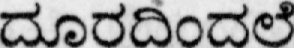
ದೂರದಿಂದಲೆ
